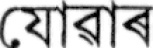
যোৱাৰ
